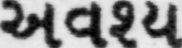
અવશ્ય
